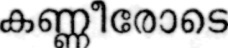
കണ്ണീരോടെ
